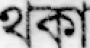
থকা
